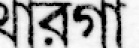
থারগা
